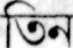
তিন
